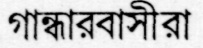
গান্ধারবাসীরা
